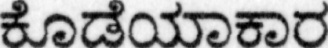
ಕೊಡೆಯಾಕಾರ
